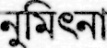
নুমিৎনা
